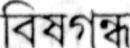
বিষগন্ধ
